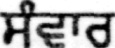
ਸੰਵਾਰ
